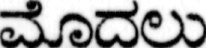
ಮೊದಲು
